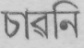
চাৱনি
